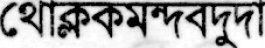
থোক্লকমন্দবদুদা
